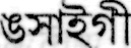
ঙসাইগী
